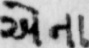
એના
